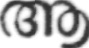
ആ
